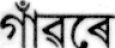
গাঁৱৰে
